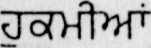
ਹੁਕਮੀਆਂ
